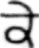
ਕੇ
